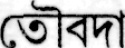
তৌবদা
